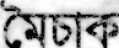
মৈচাক
